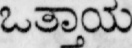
ಒತ್ತಾಯ
